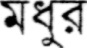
মধুর
